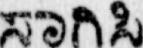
ಸಾಗಿಸಿ
